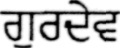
ਗੁਰਦੇਵ
